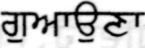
ਗੁਆਉਣਾ
